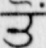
ਤੋਂ
